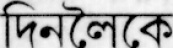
দিনলৈকে
